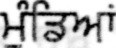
ਮੁੰਡਿਆਂ
